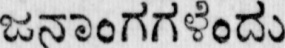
ಜನಾಂಗಗಳೆಂದು
